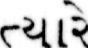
ત્યારે
